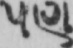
પણ
